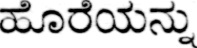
ಹೊರೆಯನ್ನು
